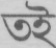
তই
